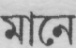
মানে
